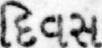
દિવસ
